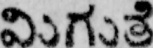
ಮಿಗುತೆ
